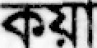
কয়া
